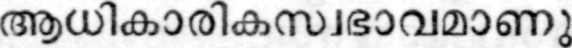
ആധികാരികസ്വഭാവമാണു
